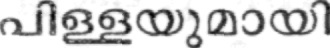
പിള്ളയുമായി
